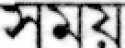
সময়
